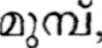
മുമ്പ്,
